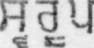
ਸ੍ਵਰੂਪ
